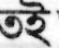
তই
